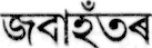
জবাহঁতৰ
